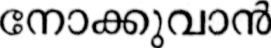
നോക്കുവാന്‍
